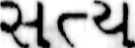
સત્ય
